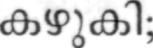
കഴുകി;
